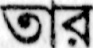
তার
